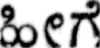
ಹೀಗೆ
